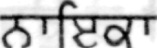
ਨਾਇਕਾ
